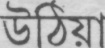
উঠিয়া
